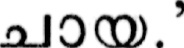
ചായ.’
